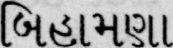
બિહામણા
